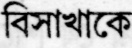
বিসাখাকে
